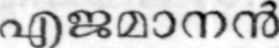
എജമാനന്‍
